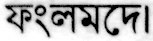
ফংলমদে।
